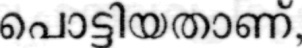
പൊട്ടിയതാണ്,
